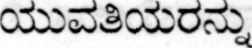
ಯುವತಿಯರನ್ನು
